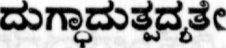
ದುಗ್ಧಾದುತ್ಪದ್ಯತೇ
